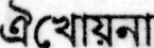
ঐখোয়না
